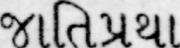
જાતિપ્રથા
